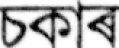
চকাৰ
